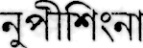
নুপীশিংনা
